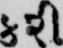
કરી
